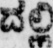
ದಲ್ಲಿ
